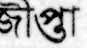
জীপ্তা
